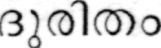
ദുരിതം
